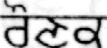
ਰੌਣਕ
